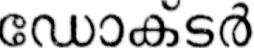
ഡോക്ടര്‍
